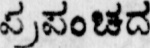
ಪ್ರಪಂಚದ
